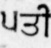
ਪਤੀ
